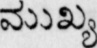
ಮುಖ್ಯ
